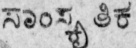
ಸಾಂಸ್ಕೃತಿಕ
